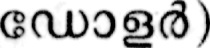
ഡോളര്‍)
